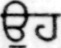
ਉਹ
